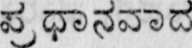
ಪ್ರಧಾನವಾದ
